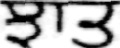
ਝਾਤ
